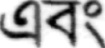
এবং
